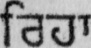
ਰਿਹਾ
